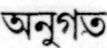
অনুগত
